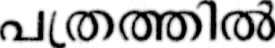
പത്രത്തില്‍
